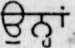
ਉਨ੍ਹਾਂ
